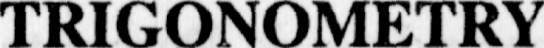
TRIGONOMETRY
